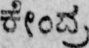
ಕೇಂದ್ರ
